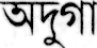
অদুগা
